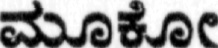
ಮೂಕೋ
